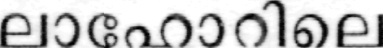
ലാഹോറിലെ
